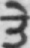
ਤੇ
